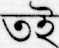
তই
